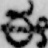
ಈ
